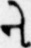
ને
